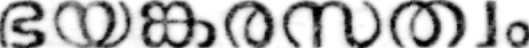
ഭയങ്കരസത്വം
